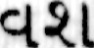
વશ
